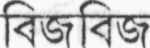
বিজবিজ
